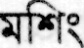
মশিং
